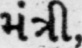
મંત્રી,
